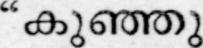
"കുഞ്ഞു
